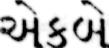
એકબે
